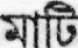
মাটি
